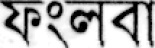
ফংলদুনা
